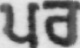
ਪਰ
